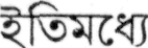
ইতিমধ্যে
